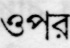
ওপর
